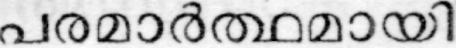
പരമാര്‍ത്ഥമായി
